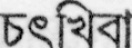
চৎখিবা
